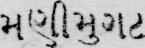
મણીમુગટ
